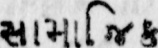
સામાજિક
